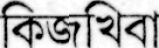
কিজখিবা
